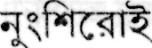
নুংশিরোই
